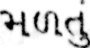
મળતું
